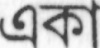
একা
